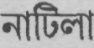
নাটিলা
